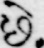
છે.
